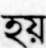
হয়
